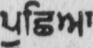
ਪੁਛਿਆ
